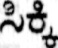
ಸಿಕ್ಕಿ
